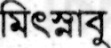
মিৎস্নাবু
